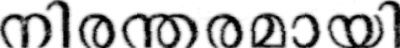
നിരന്തരമായി
